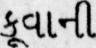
કૂવાની
